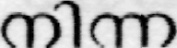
നിന്ന
